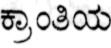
ಕ್ರಾಂತಿಯ
